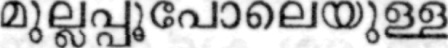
മുല്ലപ്പൂപോലെയുള്ള
